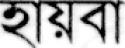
হায়বা
